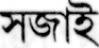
সজাই
